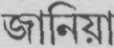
জানিয়া
